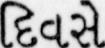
દિવસે
